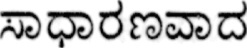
ಸಾಧಾರಣವಾದ
